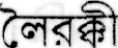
লৈরক্কী
